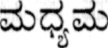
ಮಧ್ಯಮ
